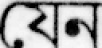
যেন
